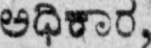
ಅಧಿಕಾರ,
